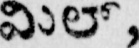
ಮಿಲ್,
